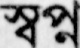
স্বপ্ন
